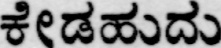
ಕೇಡಹುದು
